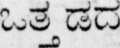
ಒತ್ತಡದ
